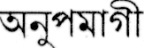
অনুপমাগী
